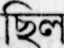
ছিল
